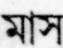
মাস
